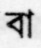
বা
